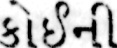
કોઈની
